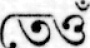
তেওঁ
